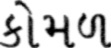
કોમળ
